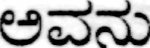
ಅವನು
